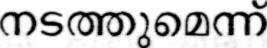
നടത്തുമെന്ന്
